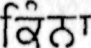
ਕਿੰਨਾ
